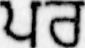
ਪਰ
